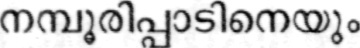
നമ്പൂരിപ്പാടിനെയും
